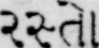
રસ્તો
